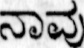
ನಾವು
